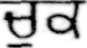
ਚੁਕ
